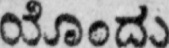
ಯೊಂದು
